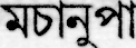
মচানুপা
